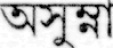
অসুম্না
